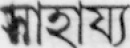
সাহায্য
